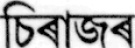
চিৰাজৰ
